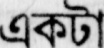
একটা
